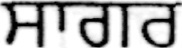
ਸਾਗਰ
